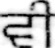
ਵੀ
